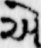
એ
